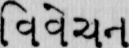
વિવેચન
